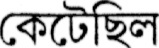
কেটেছিল
